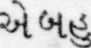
એબહુ
